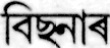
বিছনাৰ
